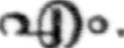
എം.
